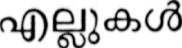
എല്ലുകള്‍
